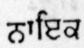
ਨਾਇਕ
